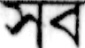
সব
